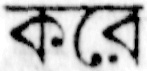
করে
